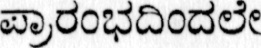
ಪ್ರಾರಂಭದಿಂದಲೇ
